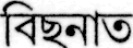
বিছনাত
